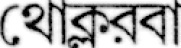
থোক্লরবা
